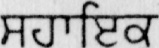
ਸਹਾਇਕ
